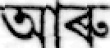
আৰু
